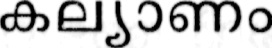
കല്യാണം
